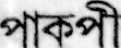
পাকপী
